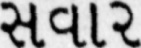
સવાર
